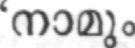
‘നാമും
